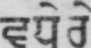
ਵਧੇਰੇ
